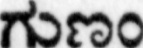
ಗುಣಂ
